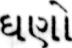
ઘણો
